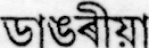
ডাঙৰীয়া
